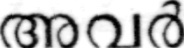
അവര്‍
